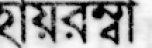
হায়রম্বা
